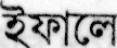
ইফালে
